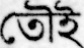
তৌই
